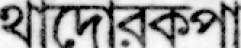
থাদোরকপা
